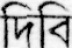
দিবি
